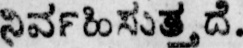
ನಿರ್ವಹಿಸುತ್ತದೆ.
